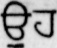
ਉਹ
